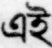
এই
